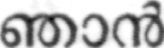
ഞാന്‍
